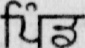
ਪਿੰਡ
